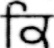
ਕਿ
